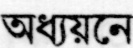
অধ্যয়নে
